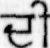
ਦੀ
